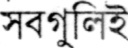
সবগুলিই
